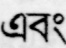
এবং
